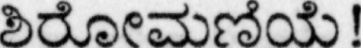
ಶಿರೋಮಣಿಯೆ!
